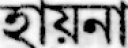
হায়না
